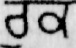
ਰੁਕ
